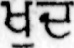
ਖੁਦ
